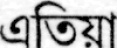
এতিয়া
